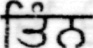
ਤਿੰਨ
